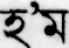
হ'ম
